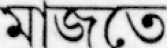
মাজতে
